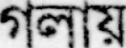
গলায়
